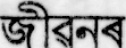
জীৱনৰ
